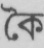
কৈ
